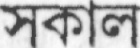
সকাল
